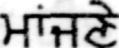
ਮਾਂਜਣੇ
